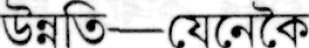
উন্নতি-যেনেকৈ
